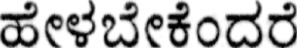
ಹೇಳಬೇಕೆಂದರೆ
